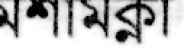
মশামক্না
